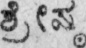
ಶ್ರೇಷ್ಠ
